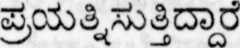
ಪ್ರಯತ್ನಿಸುತ್ತಿದ್ದಾರೆ
